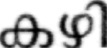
കഴി
